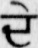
ਦੇ
